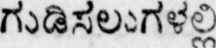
ಗುಡಿಸಲುಗಳಲ್ಲಿ
